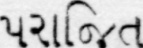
પરાજિત
